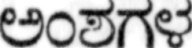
ಅಂಶಗಳ
